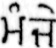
ਮੰਜੇ
